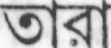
তারা
